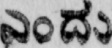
ಎಂದು
